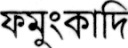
ফমুংকাদি
